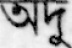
অদু
